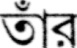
তাঁর
